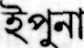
ইপুনা
